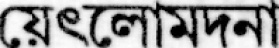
য়েৎলোমদনা
